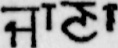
ਜਾਣਾ
